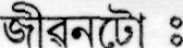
জীৱনটোঃ
